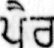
ਪੈਰ
